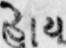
હોય
